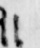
તો
